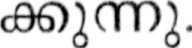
ക്കുന്നു.
